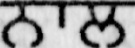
ਨਾਲ
